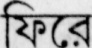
ফিরে
